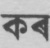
কৰ
